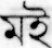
মই
